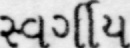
સ્વર્ગીય
